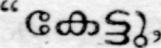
"കേട്ടു,
